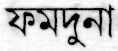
ফমদুনা
